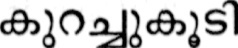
കുറച്ചുകൂടി
